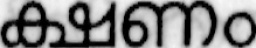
ക്ഷണം
